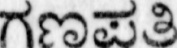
ಗಣಪತಿ
